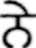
ਨੇ
